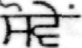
ਸੋਵੇਂ
